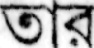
তার
